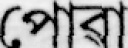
পোৱা
